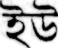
ইউ
